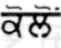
ਕੋਲੋਂ
